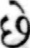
છે
